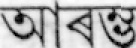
আৰম্ভ
